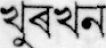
খুৰখন
